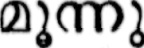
മൂന്നു
